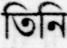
তিনি
